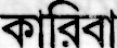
কারিবা
